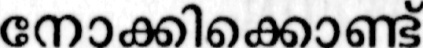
നോക്കിക്കൊണ്ട്
